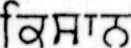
ਕਿਸਾਨ
